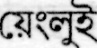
য়েংলুই
